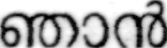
ഞാന്‍
